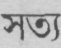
সত্য
